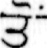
ਤੋਂ
